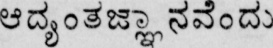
ಆದ್ಯಂತಜ್ಞಾನವೆಂದು
